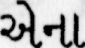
એના
